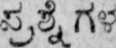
ಪ್ರಶ್ನೆಗಳ
